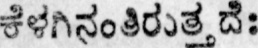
ಕೆಳಗಿನಂತಿರುತ್ತದೆ:
